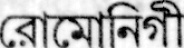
রোমোনিগী
